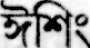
ঈশিং
